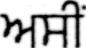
ਅਸੀਂ
